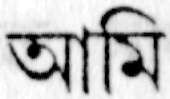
আমি
